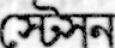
স্টেসন
